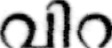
വിറ
